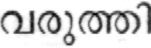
വരുത്തി
